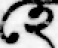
হে
